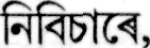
নিবিচাৰে,
